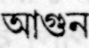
আগুন
